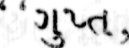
"ગુપ્ત,
